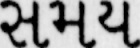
સમય
